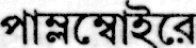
পাম্লম্বোইরে
